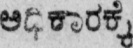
ಅಧಿಕಾರಕ್ಕೆ
